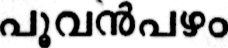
പൂവന്‍പഴം
